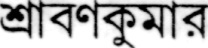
শ্রাবণকুমার
